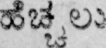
ಹೆಚ್ಚಲು
